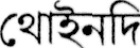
থোইনদি
